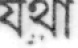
যথা
